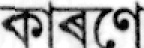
কাৰণে
